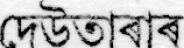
দেউতাৰাৰ
